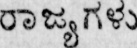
ರಾಜ್ಯಗಳು
